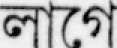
লাগে
